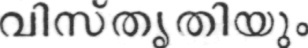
വിസ്തൃതിയും
